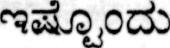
ಇಷ್ಟೊಂದು
